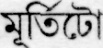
মূর্তিটো
